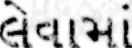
લેવામાં
